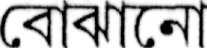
বোঝানো
